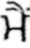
ਮੈਂ
